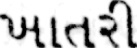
ખાતરી
